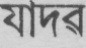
যাদৱ
